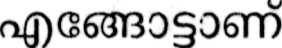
എങ്ങോട്ടാണ്
